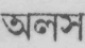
অলস
